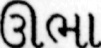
ઊભા
